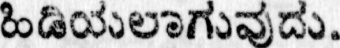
ಹಿಡಿಯಲಾಗುವುದು.
